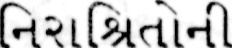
નિરાશ્રિતોની
